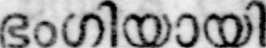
ഭംഗിയായി
